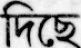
দিছে
